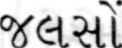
જલસોં
